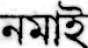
নমাই
